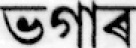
ভগাৰ
